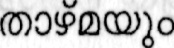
താഴ്മയും
